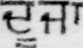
ਦੂਜਾ
